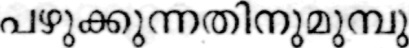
പഴുക്കുന്നതിനുമുമ്പു
